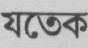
যতেক
